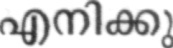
എനിക്കു
